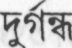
দুর্গন্ধ
